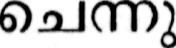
ചെന്നു
